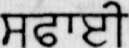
ਸਫਾਈ
